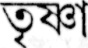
তৃষ্ণা
